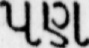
પણ
